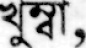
খুম্বা,
